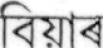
বিয়াৰ
